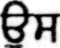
ਉਸ
